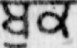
ਬੁਕ
